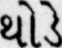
થોડે
